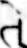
તે
